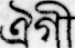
ঐগী
